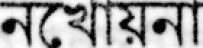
নখোয়না
